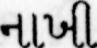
નાખી
